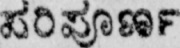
ಪರಿಪೂರ್ಣ
